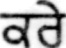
ਕਰੇ
